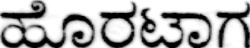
ಹೊರಟಾಗ
